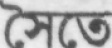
সৈতে
